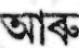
আৰু
